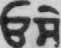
ਓਸੇ
